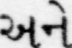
અને
